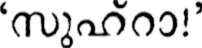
‘സുഹ്റാ!’
